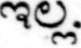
ಇಲ್ಲ.
